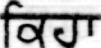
ਕਿਹਾ
